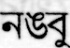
নঙবু
